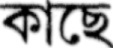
কাছে
